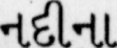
નદીના
